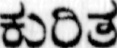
ಕುರಿತ
